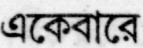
একেবারে
